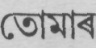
তোমাৰ
